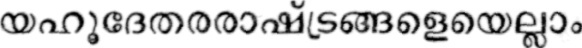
യഹൂദേതരരാഷ്ട്രങ്ങളെയെല്ലാം
